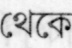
থেকে
